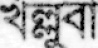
খল্লুবা
